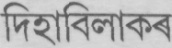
দিহাবিলাকৰ
